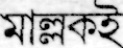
মাল্লকই
